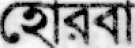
হোরবা
